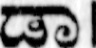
ಡಾ|
